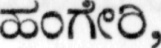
ಹಂಗೇರಿ,
